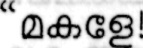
"മകളേ!
